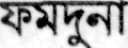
ফমদুনা
